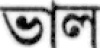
ভাল
